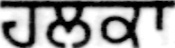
ਹਲਕਾ
